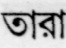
তারা
